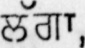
ਲੱਗਾ,
